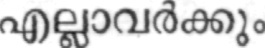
എല്ലാവര്‍ക്കും
